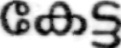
കേട്ട
